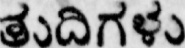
ತುದಿಗಳು
